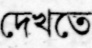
দেখতে
